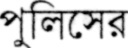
পুলিসের
